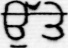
ਉੱਤੇ
